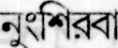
নুংশিরবা
